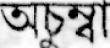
অচুম্বা
